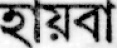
হায়বা
